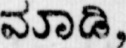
ಮಾಡಿ,
